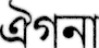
ঐগনা
